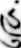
હું
